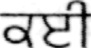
ਕਈ
